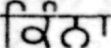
ਕਿੰਨਾ
